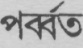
পৰ্ব্বত
